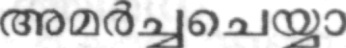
അമര്‍ച്ചചെയ്യാ
